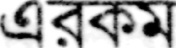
এরকম
